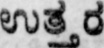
ಉತ್ತರ
